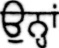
ਉਨ੍ਹਾਂ
